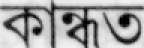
কান্ধত
